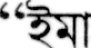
“ইমা
